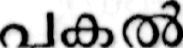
പകല്‍
